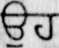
ਉਹ
